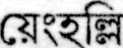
য়েংহল্লি
